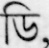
ডি,
